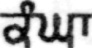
ਕੰਘਾ
